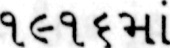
૧૯૧૬માં
